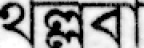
থল্লবা
